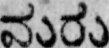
ಮರು
